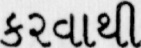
કરવાથી
